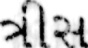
ત્રીસ
